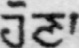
ਹੋਣਾ
